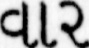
વાર
